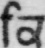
ਕਿ
